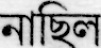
নাছিল
